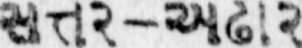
સત્તર-અઢાર
